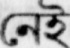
নেই
